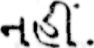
નહીં.
